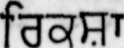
ਰਿਕਸ਼ਾ
